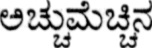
ಅಚ್ಚುಮೆಚ್ಚಿನ
